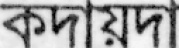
কদায়দা
